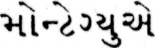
મોન્ટેગ્યુએ
